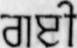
ਗਈ
